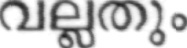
വല്ലതും
